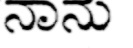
ನಾನು
